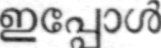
ഇപ്പോള്‍
